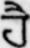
ਹੈ
